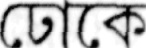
ঢোকে
